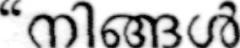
“നിങ്ങള്‍
